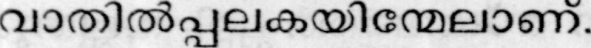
വാതില്‍പ്പലകയിന്മേലാണ്.
